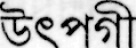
উৎপগী
